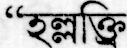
“হল্লক্ত্রি
